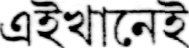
এইখানেই
